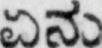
ಏನು
